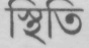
স্থিতি
